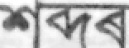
শব্দৰ
